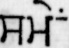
ਸਮੇਂ
